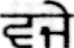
ਵਜੇ
